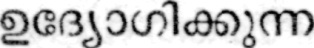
ഉദ്യോഗിക്കുന്ന
